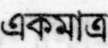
একমাত্র
